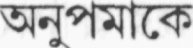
অনুপমাকে
